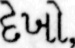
દેખો,
